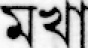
মখা
